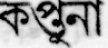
কপ্তুনা
